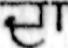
ਦਾ
